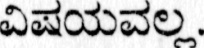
ವಿಷಯವಲ್ಲ.
